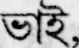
ভাই,
